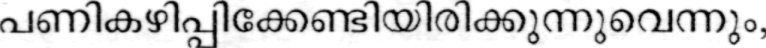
പണികഴിപ്പിക്കേണ്ടിയിരിക്കുന്നുവെന്നും,
